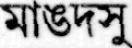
মাঙদসু
